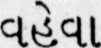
વહેવા
